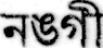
নঙগী
